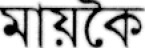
মায়কৈ
